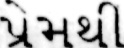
પ્રેમથી
